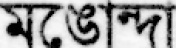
মঙোন্দা
